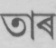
তাৰ
